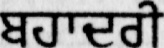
ਬਹਾਦਰੀ
